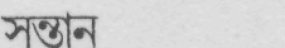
সন্তান
